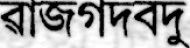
ৱাজগদবদু
